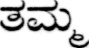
ತಮ್ಮ
